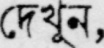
দেখুন,
